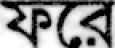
ফরে
